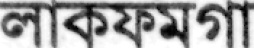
লাকফমগা
